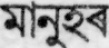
মানুহৰ
